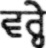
ਵਰ੍ਹੇ
